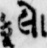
ફૂલો
